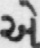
એ
